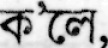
ক'লে,
